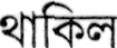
থাকিল
